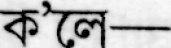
ক'লে-
